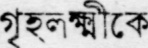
গৃহলক্ষ্মীকে
